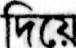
দিয়ে
